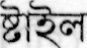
ষ্টাইল
